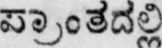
ಪ್ರಾಂತದಲ್ಲಿ
